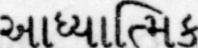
આધ્યાત્મિક
